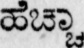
ಹೆಚ್ಚಾ
